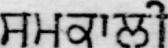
ਸਮਕਾਲੀ
